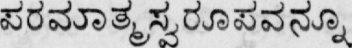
ಪರಮಾತ್ಮಸ್ವರೂಪವನ್ನೂ
